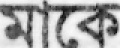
মাকে
